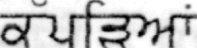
ਕੱਪੜਿਆਂ
